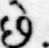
છે.
